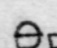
ਉਸ
